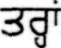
ਤਰ੍ਹਾਂ
